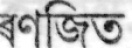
ৰণজিত
